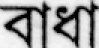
বাধা
